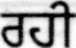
ਰਹੀ
